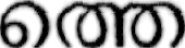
ത്തെ
